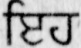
ਇਹ
